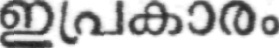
ഇപ്രകാരം
